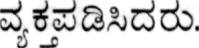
ವ್ಯಕ್ತಪಡಿಸಿದರು.
